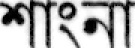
শাংনা
